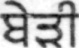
ਬੇੜੀ
